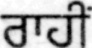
ਰਾਹੀਂ
